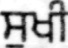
ਸੁਖੀ
